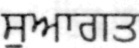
ਸੁਆਗਤ
